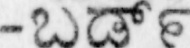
-ಬರ್ಡ್
